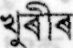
খুৰীৰ
